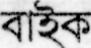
বাইক
